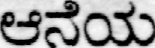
ಆನೆಯ
